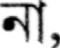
না,
